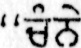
''ਚੰਨੇ
